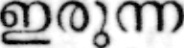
ഇരുന്ന
